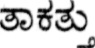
ತಾಕತ್ತು
